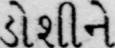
ડોશીને
